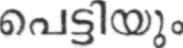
പെട്ടിയും
